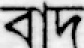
বাদ
